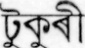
টুকুৰী
